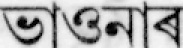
ভাওনাৰ
